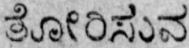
ತೋರಿಸುವ
